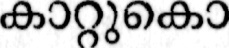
കാറ്റുകൊ
